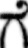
ಗೆ
